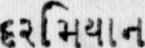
દરમિયાન
